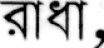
রাধা,
